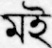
মই
